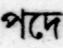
পদে
